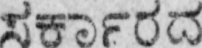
ಸರ್ಕಾರದ
